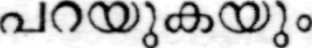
പറയുകയും
